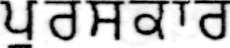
ਪੁਰਸਕਾਰ
